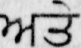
ਅਤੇ
